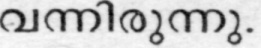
വന്നിരുന്നു.
